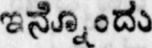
ಇನ್ನೊಂದು
